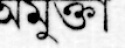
অমুক্তা
